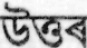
উত্তৰ
